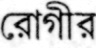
রোগীর
